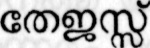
തേജസ്സ്
